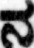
ನ
